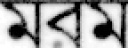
মবম
